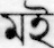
মই
